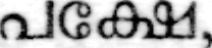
പക്ഷേ,
